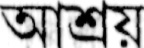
আশ্রয়
